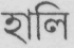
হালি
